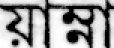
য়াম্না
